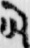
બે
